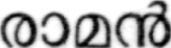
രാമന്‍
